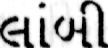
લાંબી
